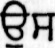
ਉਸ
